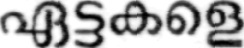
ഏട്ടകളെ
